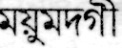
ময়ুমদগী
